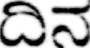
ದಿನ
